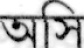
অসি
